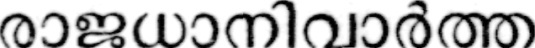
രാജധാനിവാര്‍ത്ത
